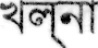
খলনা
